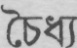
চৈধ্য
